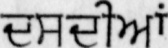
ਦਸਦੀਆਂ
